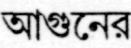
আগুনের
